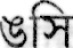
ঙসি
